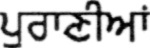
ਪੁਰਾਣੀਆਂ
